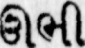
ઊભી
